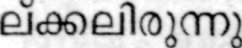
ല്ക്കലിരുന്നു
